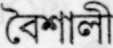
বৈশালী
